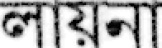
লায়না
